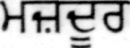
ਮਜ਼ਦੂਰ
